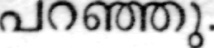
പറഞ്ഞു.
